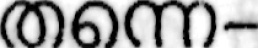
തന്നെ-
